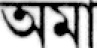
অমা
